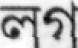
লগ
